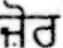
ਜ਼ੋਰ
